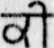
ਕੀ
